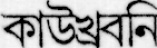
কাউখ্রবনি
